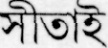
সীতাই
